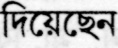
দিয়েছেন
